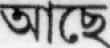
আছে
